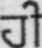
ਹੀ
